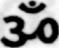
ૐ
